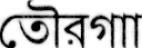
তৌরগা
